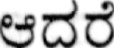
ಆದರೆ
